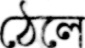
ঠেলে
